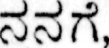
ನನಗೆ,
